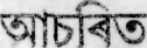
আচৰিত
